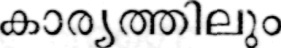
കാര്യത്തിലും
